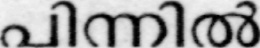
പിന്നില്‍
